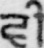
ਵੀ
